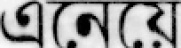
এনেয়ে
